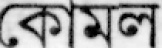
কোমল
